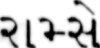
રામ્સે
